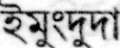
ইমুংদুদা
